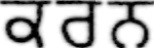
ਕਰਨ
